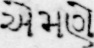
એમણે
